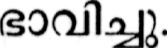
ഭാവിച്ചു.
